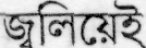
জ্বলিয়েই
